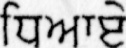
ਧਿਆਏ
